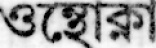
ওন্থোক্না
